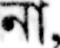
না,
